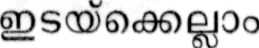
ഇടയ്ക്കെല്ലാം
